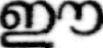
ഈ
